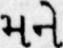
મને
